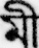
মী
